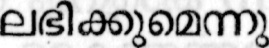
ലഭിക്കുമെന്നു
